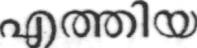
എത്തിയ
